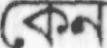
কেন
